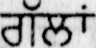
ਗੱਲਾਂ
